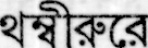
থম্বীরুরে
